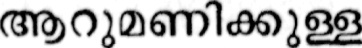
ആറുമണിക്കുള്ള
